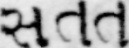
સતત
